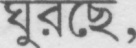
ঘুরছে,
